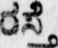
ರಸ್ತೆ
